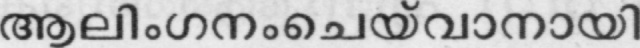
ആലിംഗനംചെയ്വാനായി
